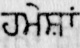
ਹਮੇਸ਼ਾਂ
